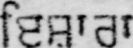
ਇਸ਼ਾਰਾ
